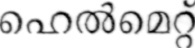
ഹെല്‍മെറ്റ്
